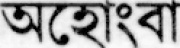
অহোংবা
